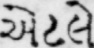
એટલે
